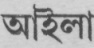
আইলা
